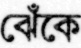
ঝেঁকে
